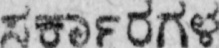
ಸರ್ಕಾರಗಳ
